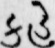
કહે
